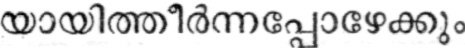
യായിത്തീര്‍ന്നപ്പോഴേക്കും
